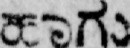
ಹಾಗು
